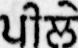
ਪੀਲੇ
